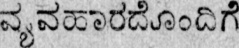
ವ್ಯವಹಾರದೊಂದಿಗೆ
